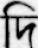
দি
